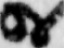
જ
